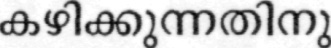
കഴിക്കുന്നതിനു
